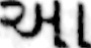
આ
